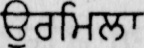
ਉਰਮਿਲਾ
